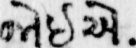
જોઈએ.
